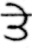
ਤੇ
